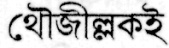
থৌজীল্লকই
